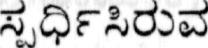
ಸ್ಪರ್ಧಿಸಿರುವ
